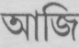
আজি
